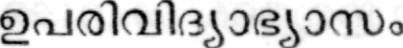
ഉപരിവിദ്യാഭ്യാസം
